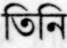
তিনি
